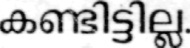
കണ്ടിട്ടില്ല.
